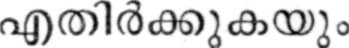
എതിര്‍ക്കുകയും
